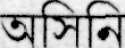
অসিনি
